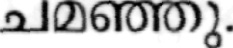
ചമഞ്ഞു.
